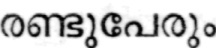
രണ്ടുപേരും
